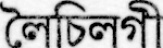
লৈচিলগী
